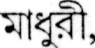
মাধুরী,
